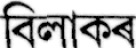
বিলাকৰ
